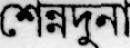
শেন্নদুনা
